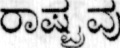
ರಾಷ್ಟ್ರವು
